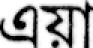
এয়া
